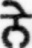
ਨੇ
